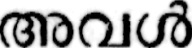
അവള്‍
